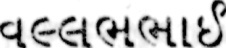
વલ્લભભાઈ
